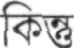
কিন্তু
